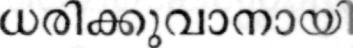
ധരിക്കുവാനായി
